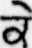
ਕੇ
